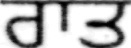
ਰਾਤ
